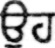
ਉਹ
